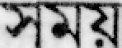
সময়
